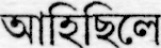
আহিছিলে
